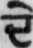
ਦੇ
